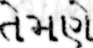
તેમણે
